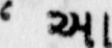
'આ
